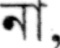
না,
